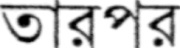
তারপর
